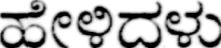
ಹೇಳಿದಳು
